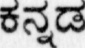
ಕನ್ನಡ
